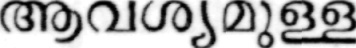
ആവശ്യമുള്ള
